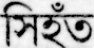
সিহঁত
